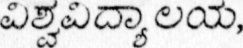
ವಿಶ್ವವಿದ್ಯಾಲಯ,
